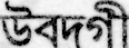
উবদগী
